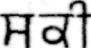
ਸਕੀ
